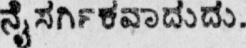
ನೈಸರ್ಗಿಕವಾದುದು.
